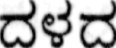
ದಳದ
